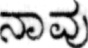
ನಾವು
